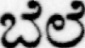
ಬೆಲೆ
